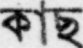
কাছ
